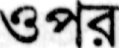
ওপর
